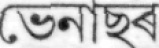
ভেনাছৰ
